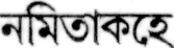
নমিতাকহে
